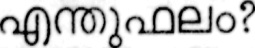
എന്തുഫലം?
